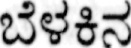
ಬೆಳಕಿನ
